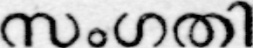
സംഗതി
